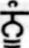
ਨੂੰ
